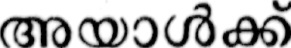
അയാള്‍ക്ക്
